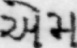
એમ
